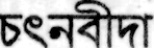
চৎনবীদা
